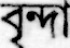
বৃ্ন্দা
